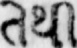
તેથી
